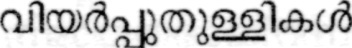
വിയര്‍പ്പുതുള്ളികള്‍
